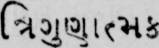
ત્રિગુણાત્મક
